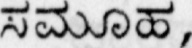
ಸಮೂಹ,
